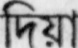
দিয়া
